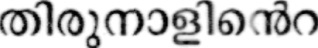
തിരുനാളിന്റെ
